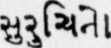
સુરુચિનો
